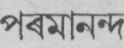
পৰমানন্দ
